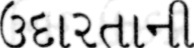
ઉદારતાની
